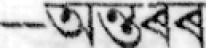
-অন্তৰৰ
